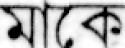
মাকে
